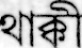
থাক্কী
